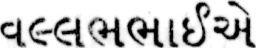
વલ્લભભાઈએ
